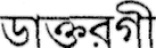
ডাক্তরগী
